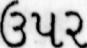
ઉપર
